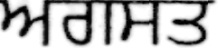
ਅਗਸਤ
